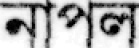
নাপল
